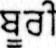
ਬੂਰੀ
